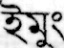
ইমুং
